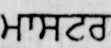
ਮਾਸਟਰ
